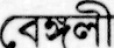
বেঙ্গলী
